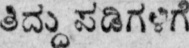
ತಿದ್ದುಪಡಿಗಳಿಗೆ
